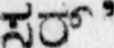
ಸರ್’
